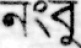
নংবু
